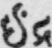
ઇંદ્ર
